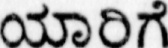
ಯಾರಿಗೆ
